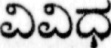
ವಿವಿಧ
